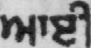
ਆਈ
